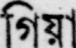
গিয়া
